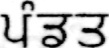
ਪੰਡਤ
